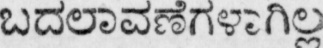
ಬದಲಾವಣೆಗಳಾಗಿಲ್ಲ.
